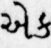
એક
